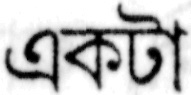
একটা
